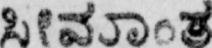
ಸೀಮಾಂತ
